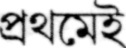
প্রথমেই
